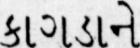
કાગડાને
